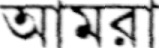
আমরা
